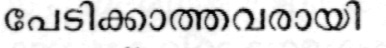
പേടിക്കാത്തവരായി
